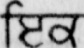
ਇਕ
